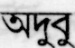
অদুবু
